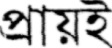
প্রায়ই
